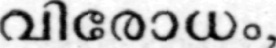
വിരോധം,
